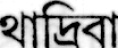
থাদ্রিবা
